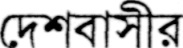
দেশবাসীর
